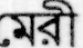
মেরী
